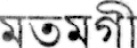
মতমগী
